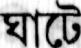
ঘাটে
